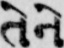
તેને
